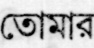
তোমার
